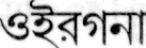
ওইরগনা
